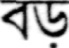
বড়
